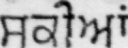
ਸਕੀਆਂ
